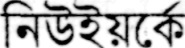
নিউইয়র্কে
